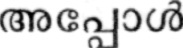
അപ്പോള്‍
